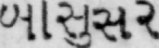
બાસુસર
